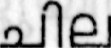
ചില
